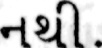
નથી.
